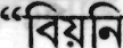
"বিয়নি
